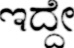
ಇದ್ದೇ
